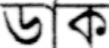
ডাক
